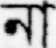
না
